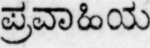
ಪ್ರವಾಹಿಯ
